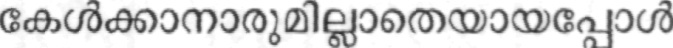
കേള്‍ക്കാനാരുമില്ലാതെയായപ്പോള്‍
